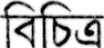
বিচিত্র
